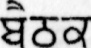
ਬੈਠਕ
